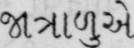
જાત્રાળુએ
